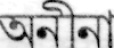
অনীনা
